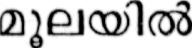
മൂലയില്‍
